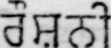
ਰੌਸ਼ਨੀ
